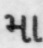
મા
